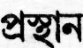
প্ৰস্থান
